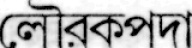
লৌরকপদা
